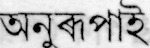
অনুৰূপাই
